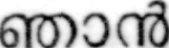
ഞാന്‍
